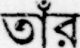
তাঁর
